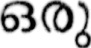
ഒരു
